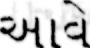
આવે
